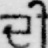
ਦੀ
